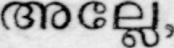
അല്ലേ,
